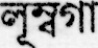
লূম্বগা
